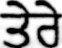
ਤੇਰੇ
